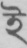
ই
